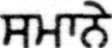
ਸਮਾਨੇ
